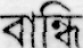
বান্ধি
